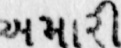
અમારી
